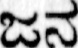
ಜನ
